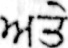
ਅਤੇ
